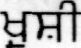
ਖ਼ੁਸ਼ੀ
